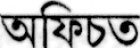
অফিচত
